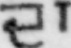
ਦਾ
